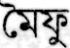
মৈফু
